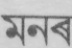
মনৰ
